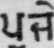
ਪੁਜੇ
